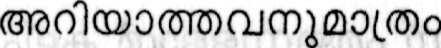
അറിയാത്തവനുമാത്രം
